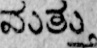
ಮತ್ತು
